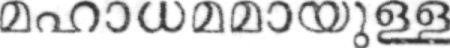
മഹാധമമായുള്ള
